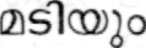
മടിയും
